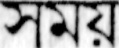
সময়
